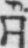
ਸੌਂ
